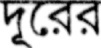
দূরের
